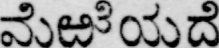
ಮೆಱೆಯದೆ
